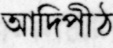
আদিপীঠ
